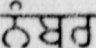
ਨੰਬਰ
